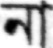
না
